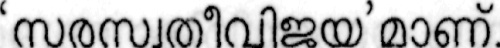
'സരസ്വതീവിജയ'മാണ്.
